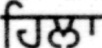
ਹਿਲਾ
